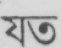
যত
